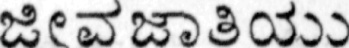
ಜೀವಜಾತಿಯು
